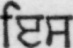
ਇਸ
